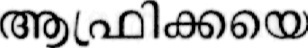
ആഫ്രിക്കയെ
